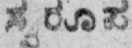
ಸ್ವರೂಪ
